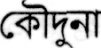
কৌদুনা
